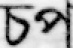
চপ
